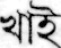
খাই
